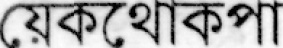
য়েকথোকপা
